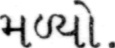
મળ્યો.
